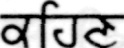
ਕਹਿਣ
